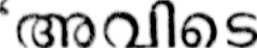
‘അവിടെ
